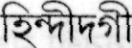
হিন্দীদগী
